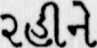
રહીને
